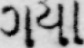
ગયા
